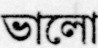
ভালো
